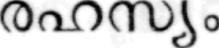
രഹസ്യം
